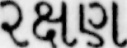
રક્ષણ
